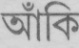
আঁকি
